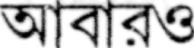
আবারও
